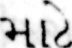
માટે
